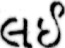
લઈ
